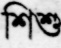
শিশু
